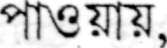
পাওয়ায়,
